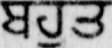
ਬਹੁਤ
